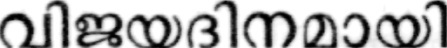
വിജയദിനമായി
